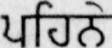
ਪਹਿਨੇ
